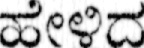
ಹೇಳಿದ
